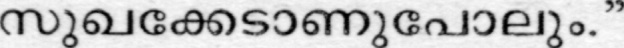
സുഖക്കേടാണുപോലും."
